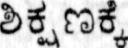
ಶಿಕ್ಷಣಕ್ಕೆ
